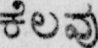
ಕೆಲವು
